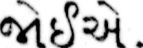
જોઈએ.
